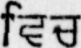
ਵਿਚ
